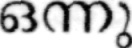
ഒന്നു
